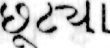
છૂટ્યા
